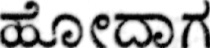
ಹೋದಾಗ
